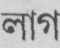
লাগ
